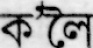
ক'লৈ
